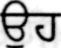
ਉਹ
